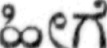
ಹೀಗೆ
